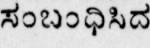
ಸಂಬಂಧಿಸಿದ
